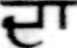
ਦਾ
